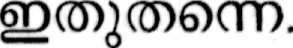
ഇതുതന്നെ.
